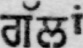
ਗੱਲਾਂ
